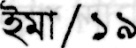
ইমা/১৯
